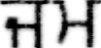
ਜਮ
